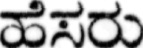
ಹೆಸರು
